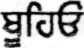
ਬੂਹਿਓਂ
